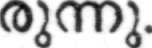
രുന്നു.
